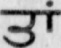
ਤਾਂ
